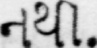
નથી.
